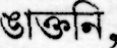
ঙাক্তনি,
